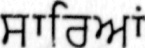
ਸਾਰਿਆਂ
